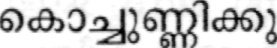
കൊച്ചുണ്ണിക്കു
